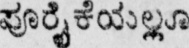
ಪೂರೈಕೆಯಲ್ಲೂ
